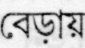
বেড়ায়
